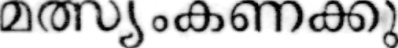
മത്സ്യംകണക്കു
